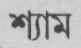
শ্যাম
